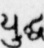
યુદ્ધ
